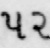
પર
